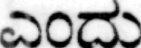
ಎಂದು
